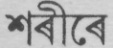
শৰীৰে
